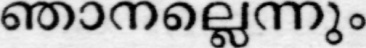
ഞാനല്ലെന്നും
